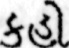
કહો
